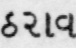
ઠરાવ
